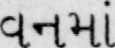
વનમાં
